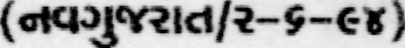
(નવગુજરાત/૨-૬-૯૪)
